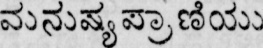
ಮನುಷ್ಯಪ್ರಾಣಿಯು
